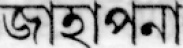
জাহাপনা
